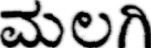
ಮಲಗಿ
